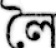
লৈ
